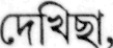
দেখিছা,
